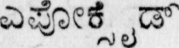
ಎಪೋಕ್ಸೈಡ್
